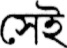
সেই
